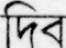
দিব
